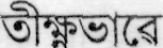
তীক্ষ্ণভাৱে
